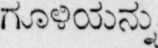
ಗೂಳಿಯನ್ನು
